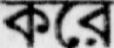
করে
